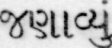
જણાવ્યું
